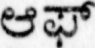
ಆಫ್
